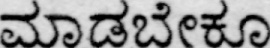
ಮಾಡಬೇಕೂ
